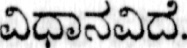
ವಿಧಾನವಿದೆ.
